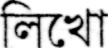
লিখো
